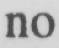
no
